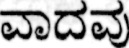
ವಾದವು
